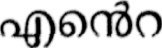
എന്റെ
